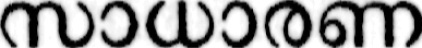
സാധാരണ
